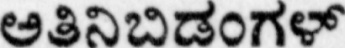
ಅತಿನಿಬಿಡಂಗಳ್
